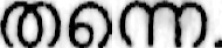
തന്നെ.
